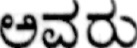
ಅವರು
